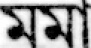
মমা
